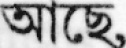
আছে,
